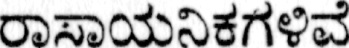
ರಾಸಾಯನಿಕಗಳಿವೆ
